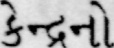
કેન્દ્રનો
